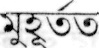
মুহূর্তত
